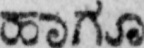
ಹಾಗೂ
